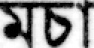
মচা
